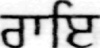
ਰਾਇ
